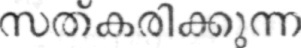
സത്കരിക്കുന്ന
